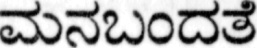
ಮನಬಂದತೆ
